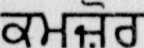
ਕਮਜ਼ੋਰ
